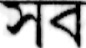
সব
